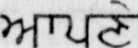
ਆਪਣੇ
